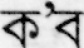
ক'ব
